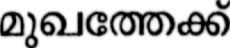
മുഖത്തേക്ക്
